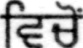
ਵਿਚੋਂ
